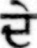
ਦੇ
